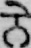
ਨੇ
